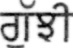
ਗੁੱਝੀ
